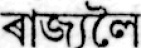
ৰাজ্যলৈ
